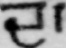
ਦਾ
